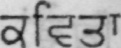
ਕਵਿਤਾ
